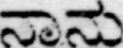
ನಾನು
